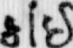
કાંઈ
